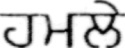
ਹਮਲੇ
